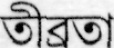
তীব্রতা
